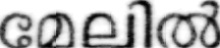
മേലില്‍
